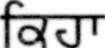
ਕਿਹਾ
